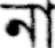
না
